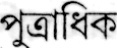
পুত্রাধিক
